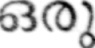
ഒരു
